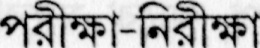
পরীক্ষা-নিরীক্ষা
